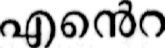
എന്റെ
